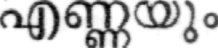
എണ്ണയും
